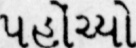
પહોંચ્યો
